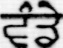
ਵੰਡੇ
